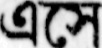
এসে
